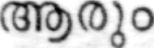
ആരും
